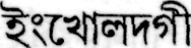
ইংখোলদগী
